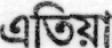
এতিয়া
